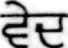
ਵੇਦ
